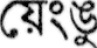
য়েংঙু
